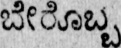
ಬೇರೊಬ್ಬ
